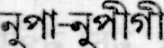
নুপা-নুপীগী
